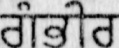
ਗੰਭੀਰ
